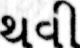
થવી
